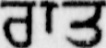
ਰਾਤ
